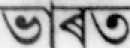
ভাৰত
